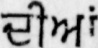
ਦੀਆਂ
